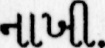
નાખી.
